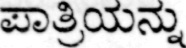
ಪಾತ್ರಿಯನ್ನು
